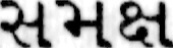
સમક્ષ
